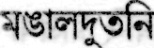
মঙালদুতনি
